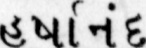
હર્ષાનંદ
